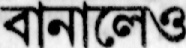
বানালেও
